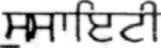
ਸੁਸਾਇਟੀ
